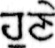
ਹੁਣੇ
